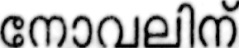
നോവലിന്
